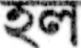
হল
